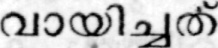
വായിച്ചത്
